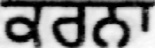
ਕਰਨਾ
